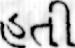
હતી
